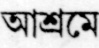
আশ্রমে
